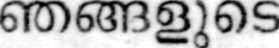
ഞങ്ങളുടെ
